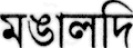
মঙালদি
